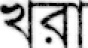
খরা
